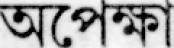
অপেক্ষা
